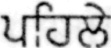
ਪਹਿਲੇ
